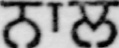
ਨਾਲ
